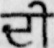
ਦੀ
